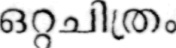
ഒറ്റചിത്രം
